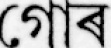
গোৰ
